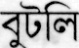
বুটলি
